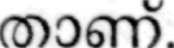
താണ്.
